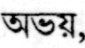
অভয়,
